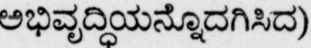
ಅಭಿವೃದ್ಧಿಯನ್ನೊದಗಿಸಿದ)
